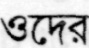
ওদের
